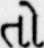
તો
